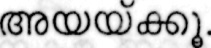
അയയ്ക്കൂ.
